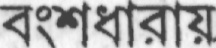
বংশধারায়
